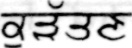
ਕੁੜੱਤਣ
